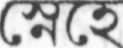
স্নেহে
